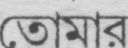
তোমার
